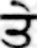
ਤੇ
